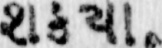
શક્યા.
